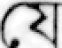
যে
